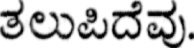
ತಲುಪಿದೆವು.
